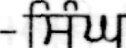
-ਸਿੰਘ
